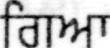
ਗਿਆ
